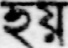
হয়
